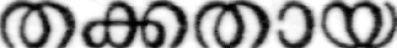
തക്കതായ
